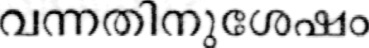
വന്നതിനുശേഷം
